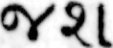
જશ
